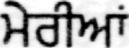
ਮੇਰੀਆਂ
